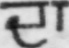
ਦਾ
